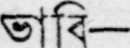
ভাবি—
